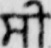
ਸੀ
